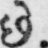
છે.
